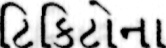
ટિકિટોના
